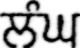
ਲੰਘ
